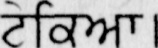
ਟੇਕਿਆ।
